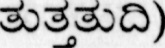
ತುತ್ತತುದಿ)
